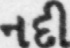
નદી
